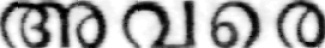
അവരെ
